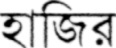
হাজির
